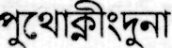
পুথোক্নীংদুনা
